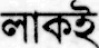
লাকই
